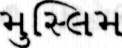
મુસ્લિમ
